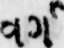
વર્ગ
